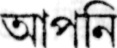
আপনি
